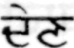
ਦੇਣ
